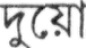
দুয়ো
